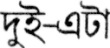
দুই-এটা
